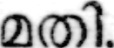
മതി.
